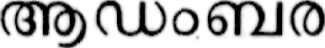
ആഡംബര
